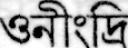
ওনীংদ্রি
